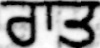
ਰਾਤ
